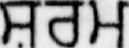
ਸ਼ਰਮ
